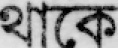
থাকে
